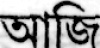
আজি
